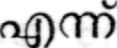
എന്ന്
